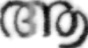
ആ
